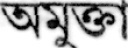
অমুক্তা
